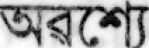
অৱশ্যে
